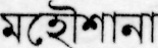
মহৌশানা
